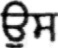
ਉਸ
